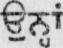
ਉਨ੍ਹਾਂ
